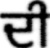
ਦੀ
